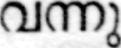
വന്നു
